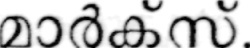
മാര്‍ക്സ്.
